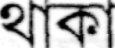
থাকা
